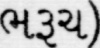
ભરૂચ)
